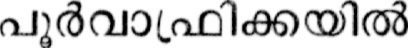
പൂര്‍വാഫ്രിക്കയില്‍
